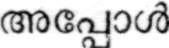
അപ്പോള്‍
